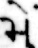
મેં
